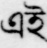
এই
